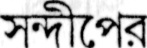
সন্দীপের
